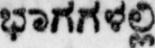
ಭಾಗಗಳಲ್ಲಿ
